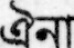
ঐনা
